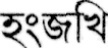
হংজখি
